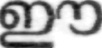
ഈ
